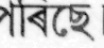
পৰিছে
